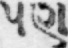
પણ
